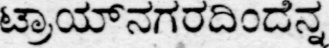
ಟ್ರಾಯ್ ನಗಲದಿಂದೆನ್ನ
